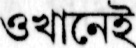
ওখানেই
